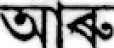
আৰু
